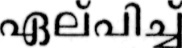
ഏല്പിച്ച്
